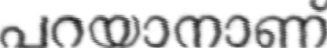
പറയാനാണ്
